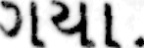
ગયા.
